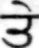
ਤੇ
